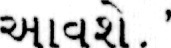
આવશે.'
